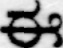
ಈ
